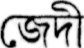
জেদী
